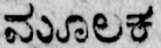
ಮೂಲಕ
